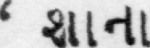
'શાના
